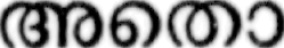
അതൊ
